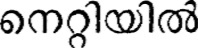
നെറ്റിയില്‍
